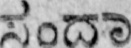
ಸಂದಾ
